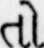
તો
